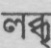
লব্ধৃ
